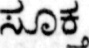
ಸೂಕ್ತ
